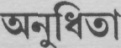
অনুধিতা
